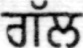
ਗੱਲ
